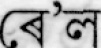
ৰে'ল
